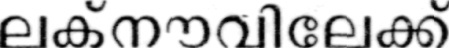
ലക്നൌവിലേക്ക്
